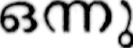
ഒന്നു
